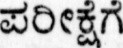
ಪರೀಕ್ಷೆಗೆ
